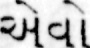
એવો
